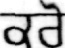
ਕਰੋ
